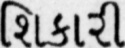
શિકારી
